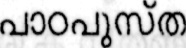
പാഠപുസ്ത
